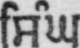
ਸਿੰਘ
